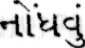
નોંધવું
